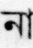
না
